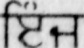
ਇੰਜ
